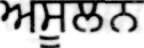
ਅਸੂਲਨ
